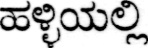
ಹಳ್ಳಿಯಲ್ಲಿ
